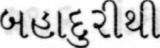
બહાદુરીથી
